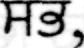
ਸਭ,
